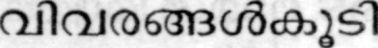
വിവരങ്ങള്‍കൂടി
